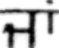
ਜਾਂ
